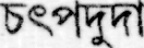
চৎপদুদা
